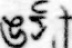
ঙসী
